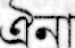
ঐনা
